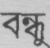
বন্ধু
